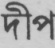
দীপ
